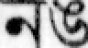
নঙ
